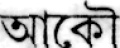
আকৌ
